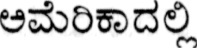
ಅಮೆರಿಕಾದಲ್ಲಿ
